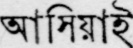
আসিয়াই
